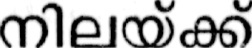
നിലയ്ക്ക്
